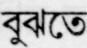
বুঝতে
